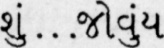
શું...જોવુંય
